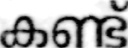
കണ്ട്
